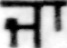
ਜਾ
